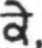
ਕੇ,
